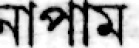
নাপাম
